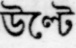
উল্টে
